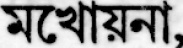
মখোয়না,
